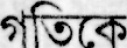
গতিকে
